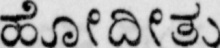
ಹೋದೀತು
